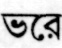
ভরে
